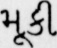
મૂકી
